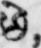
છે,
